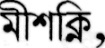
মীশক্নি,
